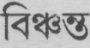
বিঞ্চন্ত
